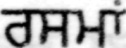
ਰਸਮਾਂ
